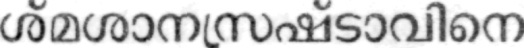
ശ്മശാനസ്രഷ്ടാവിനെ
